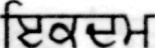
ਇਕਦਮ
